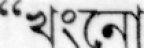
"খংনো
